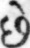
છે
